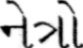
નેત્રો
